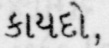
કાયદો,
